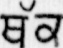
ਥੱਕ
